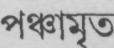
পঞ্চামৃত
